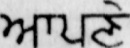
ਆਪਣੇ
